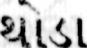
થોડા
